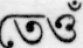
তেওঁ
